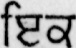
ਇਕ
